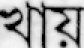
খায়
